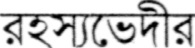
রহস্যভেদীর
